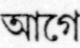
আগে
